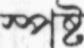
স্পষ্ট
